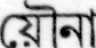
য়ৌনা
